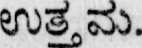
ಉತ್ತಮ.
